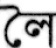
লৈ
